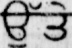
ਉੱਤੇ
